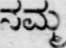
ನಮ್ಮ
